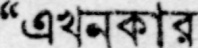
‘‘এখনকার
